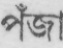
পঁজা
